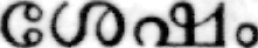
ശേഷം
